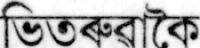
ভিতৰুৱাকৈ
